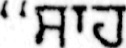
''ਸਾਹ
